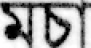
মচা
